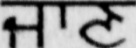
ਜਾਣ
